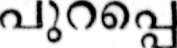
പുറപ്പെ
